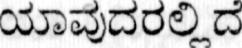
ಯಾವುದರಲ್ಲಿದೆ
